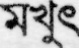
মখুৎ
